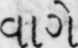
વાગે
